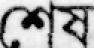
শেষ
